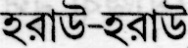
হরাউ-হরাউ
